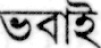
ভবাই
